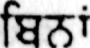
ਬਿਨਾਂ
